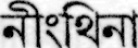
নীংথিনা
